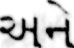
અને
